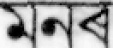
মনৰ
